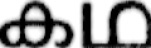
കഥ
